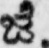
ಜೆ.
